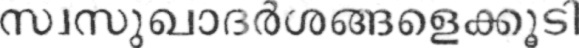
സ്വസുഖാദര്‍ശങ്ങളെക്കൂടി
